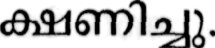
ക്ഷണിച്ചു.
